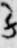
કે
